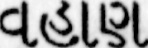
વહાણ
